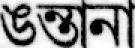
ঙন্তানা
